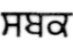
ਸਬਕ
